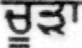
ਚੂੜਾ
